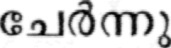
ചേര്‍ന്നു
